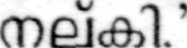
നല്കി.’
